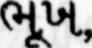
ભૂખ,
